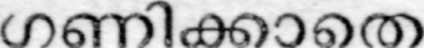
ഗണിക്കാതെ
